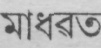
মাধৱত
